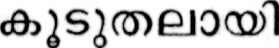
കൂടുതലായി
